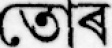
তোৰ
